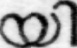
യി
